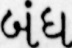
બંધ
